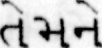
તેમને
